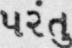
પરંતુ
